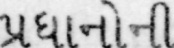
પ્રધાનોની
